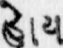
હોય
